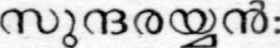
സുന്ദരയ്യന്‍:
